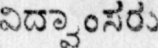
ವಿದ್ವಾಂಸರು
